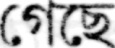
গেছে
